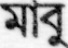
মাবু
